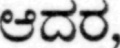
ಆದರ,
